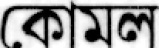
কোমল
